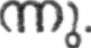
ന്നു.
